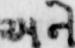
અને
